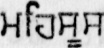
ਮਹਿਸੂਸ
